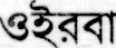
ওইরবা
